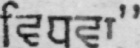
ਵਿਧਵਾ''
